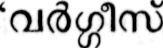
‘വര്‍ഗ്ഗീസ്
